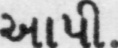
આપી.
